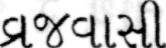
વ્રજવાસી
